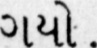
ગયો.
